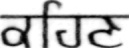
ਕਹਿਣ
